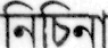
নিচিনা
